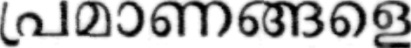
പ്രമാണങ്ങളെ
